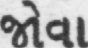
જોવા
